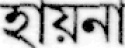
হায়না
